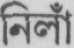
নিলাঁ
